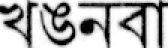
খঙনবা
